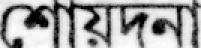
শোয়দনা
